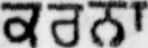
ਕਰਨਾ
